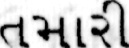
તમારી
